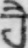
ਹੈ
